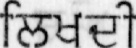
ਲਿਖਦੀ
